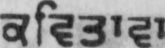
ਕਵਿਤਾਵਾ
